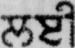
ਲਈ
